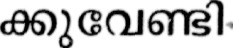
ക്കുവേണ്ടി
